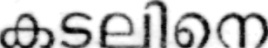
കടലിനെ
